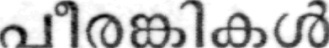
പീരങ്കികള്‍
